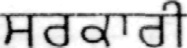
ਸਰਕਾਰੀ
